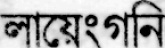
লায়েংগনি
